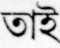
তাই
